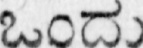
ಒಂದು
